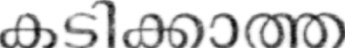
കടിക്കാത്ത
